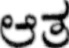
ಆತ
